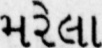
મરેલા
